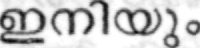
ഇനിയും
